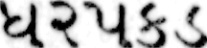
ધરપકડ
